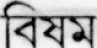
বিষম
